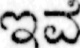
ಇವೆ
